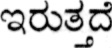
ಇರುತ್ತದೆ
